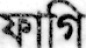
ফাগি
